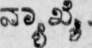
ವ್ಯಾಖ್ಯೆ
